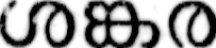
ശങ്കര
